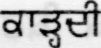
ਕਾੜ੍ਹਦੀ
